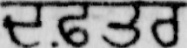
ਦਫ਼ਤਰ
